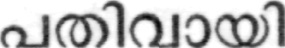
പതിവായി
